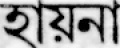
হায়না
